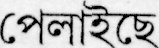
পেলাইছে
